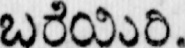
ಬರೆಯಿರಿ.
